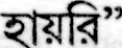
হায়রি”
